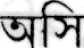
অসি
